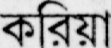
করিয়া
